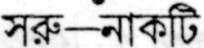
সরু—নাকটি
